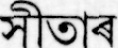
সীতাৰ
